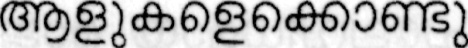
ആളുകളെക്കൊണ്ടു
